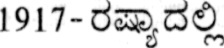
1917-ರಷ್ಯಾದಲ್ಲಿ
